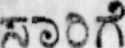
ಸಾರಿಗೆ
